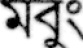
মবুং
